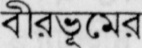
বীরভূমের
